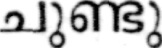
ചുണ്ടു
